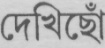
দেখিছোঁ
